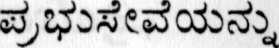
ಪ್ರಭುಸೇವೆಯನ್ನು
